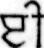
ਈ
